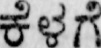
ಕೆಳಗೆ
